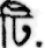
টি.
